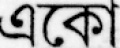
একো
